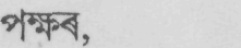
পক্ষৰ,
